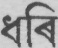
ধৰি
